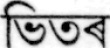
ভিতৰ
